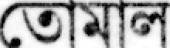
তোমাল
